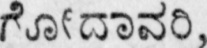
ಗೋದಾವರಿ,
